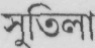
সুতিলা
